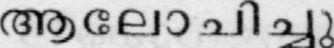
ആലോചിച്ചു
